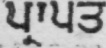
ਪ੍ਰਾਪਤ
